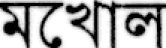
মখোল
